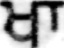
ਖਾ
